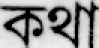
কথা
